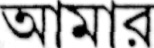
আমার
